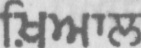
ਖ਼ਿਆਲ
